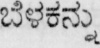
ಬೆಳಕನ್ನು
